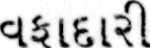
વફાદારી
